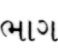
ભાગ
